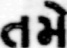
તમે
